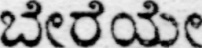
ಬೇರೆಯೇ
